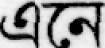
এনে
